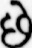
છે
